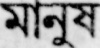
মানুষ
